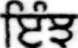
ਇੰਝ
